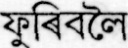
ফুৰিবলৈ
